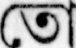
তো
